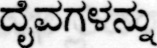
ದೈವಗಳನ್ನು
